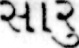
સારુ
